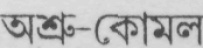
অশ্ৰু-কোমল
